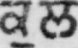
ਕੁਲ
